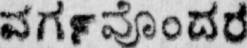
ವರ್ಗವೊಂದರ
